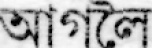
আগলৈ
